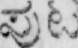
ಪುಟ
